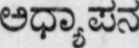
ಅಧ್ಯಾಪನ
